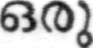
ഒരു
